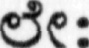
ಲೇ:
